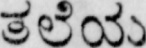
ತಲೆಯ
